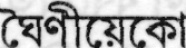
ঘৈণীয়েকো
